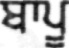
ਬਾਪੂ
